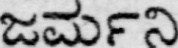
ಜರ್ಮನಿ
